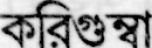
করিগুম্বা
